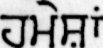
ਹਮੇਸ਼ਾਂ
